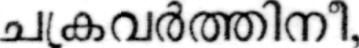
ചക്രവര്‍ത്തിനീ,
